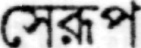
সেরূপ
